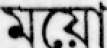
ময়ো
